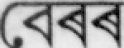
বেৰৰ
